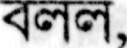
বলল,
